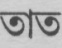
তাত
